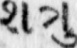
શત્રુ
